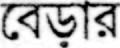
বেড়ার
